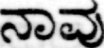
ನಾವು
